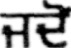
ਜਦੋਂ
